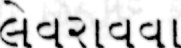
લેવરાવવા
